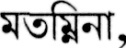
মতম্নিনা,
